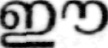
ഈ
